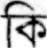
কি
